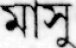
মাসু
